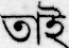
তাই
